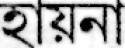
হায়না
